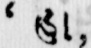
'હા,
